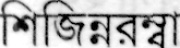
শিজিন্নরম্বা
